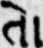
તો
